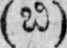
(ಬಿ)
